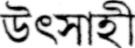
উৎসাহী
